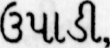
ઉપાડી,
